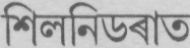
শিলনিডৰাত
